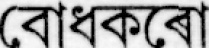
বোধকৰো
